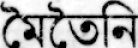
মৈতৈনি
